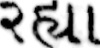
રહ્યા
